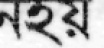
নহয়
